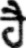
ਹੈ
